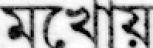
মখোয়
